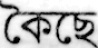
কৈছে
